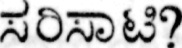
ಸರಿಸಾಟಿ?
